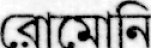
রোমোনি
